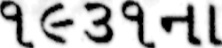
૧૯૩૧ના
